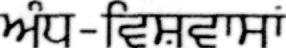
ਅੰਧ-ਵਿਸ਼ਵਾਸਾਂ
